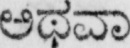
ಅಥವಾ
